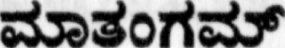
ಮಾತಂಗಮ್
